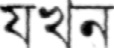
যখন
